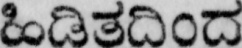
ಹಿಡಿತದಿಂದ
